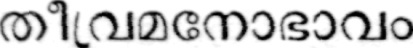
തീവ്രമനോഭാവം
